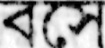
বসে
